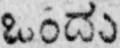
ಒಂದು
